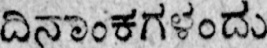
ದಿನಾಂಕಗಳಂದು
